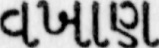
વખાણ
